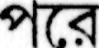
পরে
